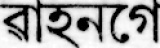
ৱাহনগে
